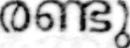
രണ്ടു
